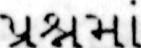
પ્રશ્નમાં
